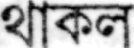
থাকল
